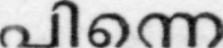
പിന്നെ
